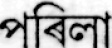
পৰিলা
